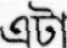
এটা
